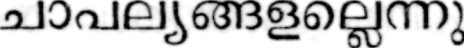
ചാപല്യങ്ങളല്ലെന്നു
